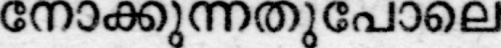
നോക്കുന്നതുപോലെ
